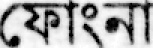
ফোংনা
